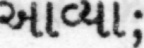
આવ્યા;
